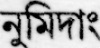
নুমিদাং
